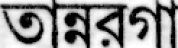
তান্নরগা
